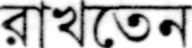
রাখতেন
